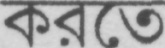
করতে
